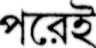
পরেই
